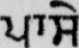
ਪਾਸੇ
